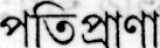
পতিপ্ৰাণা
